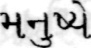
મનુષ્યે
